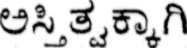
ಅಸ್ತಿತ್ವಕ್ಕಾಗಿ
